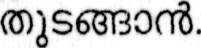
തുടങ്ങാന്‍.
